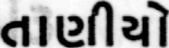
તાણીયો
